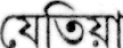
যেতিয়া
